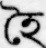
হৈ
